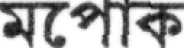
মপোক
